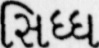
સિધ્ધ
